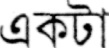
একটা
